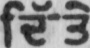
ਦਿੱਤੇ
